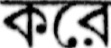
করে
